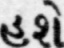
હશે
